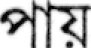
পায়
